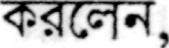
করলেন,
